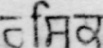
ਰਸਿਕ
